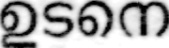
ഉടനെ
